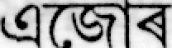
এজোৰ
